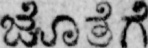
ಜೊತೆಗೆ
